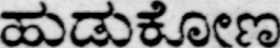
ಹುಡುಕೋಣ
